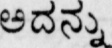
ಅದನ್ನು
